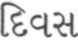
દિવસ
